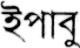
ইপাবু
